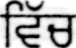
ਵਿੱਚ
